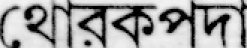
থোরকপদা
